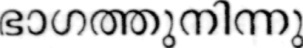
ഭാഗത്തുനിന്നു
